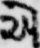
એ
